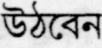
উঠবেন
